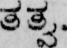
ತತ್ವ.
